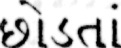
છોડતાં
